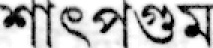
শাৎপগুম
